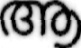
ആ
